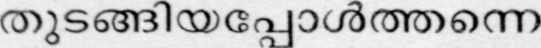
തുടങ്ങിയപ്പോള്‍ത്തന്നെ
